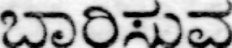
ಬಾರಿಸುವ
